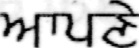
ਆਪਣੇ
